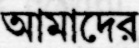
আমাদের
